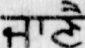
ਜਾਣੈ
